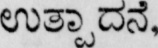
ಉತ್ಪಾದನೆ,
